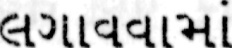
લગાવવામાં
